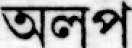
অলপ
